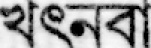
খৎনবা
